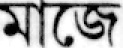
মাজে
